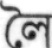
লৈ
